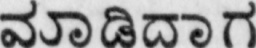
ಮಾಡಿದಾಗ
